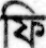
ফি
